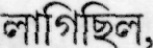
লাগিছিল,
